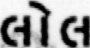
લોલ
